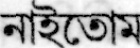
নাইতোম
